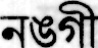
নঙগী
